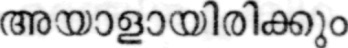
അയാളായിരിക്കും
